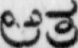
ಆತ
